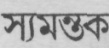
স্যমন্তক
